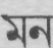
মন
